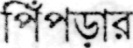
পিঁপড়ার
